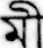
মী
